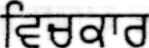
ਵਿਚਕਾਰ
